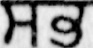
ਸਭ
